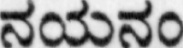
ನಯನಂ
